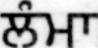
ਲੰਮਾ
